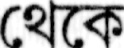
থেকে
